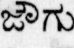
ಜೌಗು
